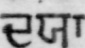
ਦਯਾ
